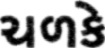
ચળકે
